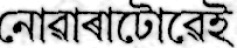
নোৱাৰাটোৱেই
